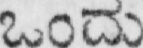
ಒಂದು
